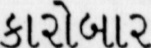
કારોબાર
